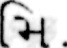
મિ.
